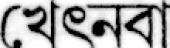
খেৎনবা
